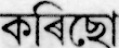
কৰিছো
